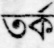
তর্ক
